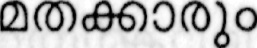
മതക്കാരും
